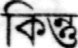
কিন্তু
